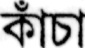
কাঁচা
